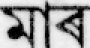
মাৰ
